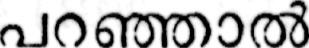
പറഞ്ഞാല്‍
